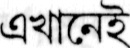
এখানেই
